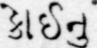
કોઈનું
